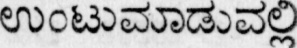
ಉಂಟುಮಾಡುವಲ್ಲಿ
